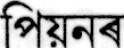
পিয়নৰ
